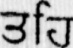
ਤਹਿ
